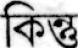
কিন্তু
